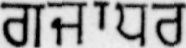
ਗਜਾਧਰ
